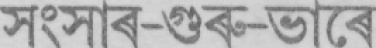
সংসাৰ-গুৰু-ভাৰে
